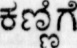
ಕಣ್ಣಿಗೆ
